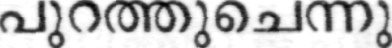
പുറത്തുചെന്നു
